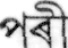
পৰী
